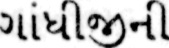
ગાંધીજીની
